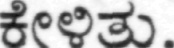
ಕೇಳಿತು.
